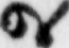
જ
